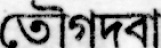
তৌগদবা
